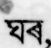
ঘৰ,
